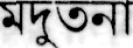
মদুতনা
